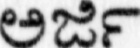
ಅರ್ಜಿ
